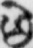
છે
